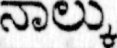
ನಾಲ್ಕು
